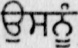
ਉਸਨੂੰ
